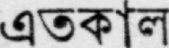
এতকাল
